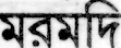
মরমদি
